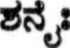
ಶನೈಃ
